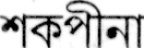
শকপীনা
